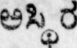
ಅಸ್ಥಿರ
